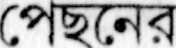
পেছনের
